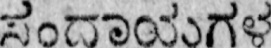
ಸಂದಾಯಗಳ
